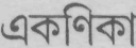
একণিকা
